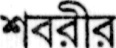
শবরীর
